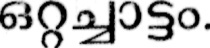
ഒറ്റച്ചാട്ടം.
